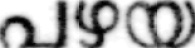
പഴയ
